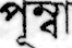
পূম্বা
